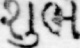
શુભ
